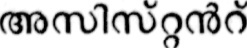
അസിസ്റ്റന്റ്
